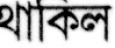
থাকিল
